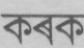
কৰক
